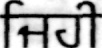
ਜਿਹੀ
